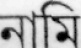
নামি
